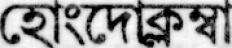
হোংদোক্লম্বা
